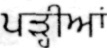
ਪੜ੍ਹੀਆਂ
